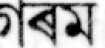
গৰম
